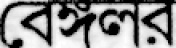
বেঙ্গলর
